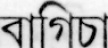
বাগিচা
